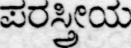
ಪರಸ್ತ್ರೀಯ
